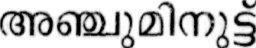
അഞ്ചുമിനുട്ട്
